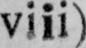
viii)
